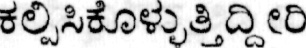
ಕಲ್ಪಿಸಿಕೊಳ್ಳುತ್ತಿದ್ದೀರಿ
